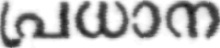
പ്രധാന
